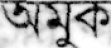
অমুক
